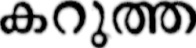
കറുത്ത
